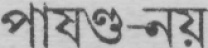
পাষণ্ড-নয়
